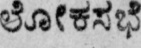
ಲೋಕಸಭೆ
